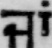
ਜਾਂ
